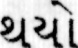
થયો
